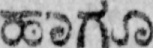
ಹಾಗೂ
